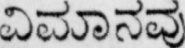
ವಿಮಾನವು
